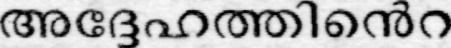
അദ്ദേഹത്തിന്റെ
